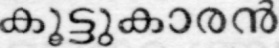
കൂട്ടുകാരന്‍
